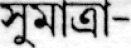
সুমাত্রা-
